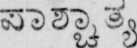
ಪಾಶ್ಚಾತ್ಯ
